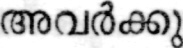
അവര്‍ക്കു
